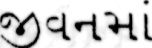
જીવનમાં
